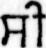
ਸੀ
